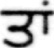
ਤਾਂ
